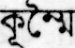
কূম্মৈ
